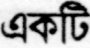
একটি
